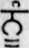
ਨੂੰ
